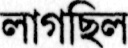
লাগছিল
